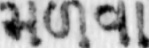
મળવા
